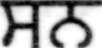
ਸਨ
